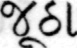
જૂઠા
